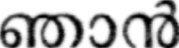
ഞാന്‍
